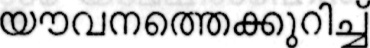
യൗവനത്തെക്കുറിച്ച്
